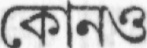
কোনও
